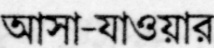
আসা-যাওয়ার
